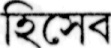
হিসেব
